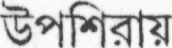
উপশিরায়
